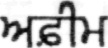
ਅਫ਼ੀਮ
